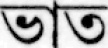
ভাত
